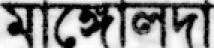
মাঙ্গোলদা
